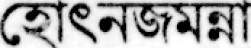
হোৎনজমন্না
